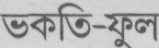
ভকতি-ফুল
